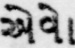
એવો
